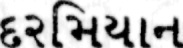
દરમિયાન
